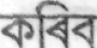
কৰিব
